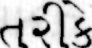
તરીકે
